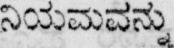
ನಿಯಮವನ್ನು
